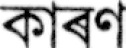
কাৰণ
